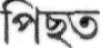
পিছত
